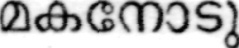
മകനോടു
